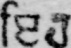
ਇਹ
